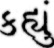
કહ્યું
